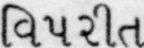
વિપરીત
